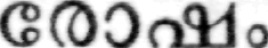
രോഷം
